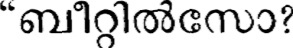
"ബീറ്റില്‍സോ?
